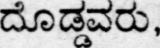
ದೊಡ್ಡವರು,
